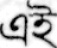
এই
